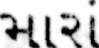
મારાં
